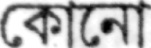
কোনো
